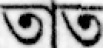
তাত
